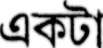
একটা
